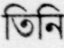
তিনি
